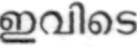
ഇവിടെ
